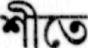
শীতে
